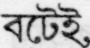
বটেই,
